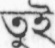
তুই
